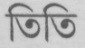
তিতি
